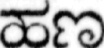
ಹಣ
